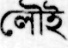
লৌই
